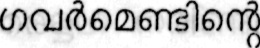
ഗവര്‍മെണ്ടിന്റെ
